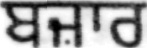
ਬਜ਼ਾਰ
